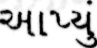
આપ્યું
